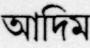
আদিম
